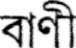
বাণী
